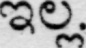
ಇಲ್ಲ.
